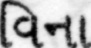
વિના
